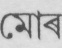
মোৰ
